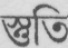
স্তুতি
